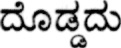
ದೊಡ್ಡದು
